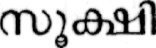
സൂക്ഷി
